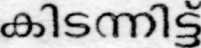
കിടന്നിട്ട്
